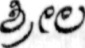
ಶ್ರೀಲ
